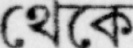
থেকে
